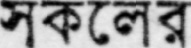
সকলের
